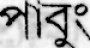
পাবুং
